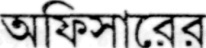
অফিসারের
